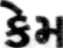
કેમ
